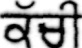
ਕੱਚੀ
